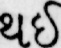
થઈ
